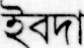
ইবদা
